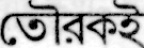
তৌরকই
